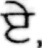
ਏ,
